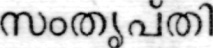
സംതൃപ്തി
